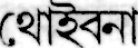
থোইবনা
